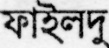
ফাইলদু
